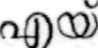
എയ്
